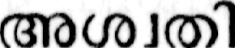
അശ്വതി
